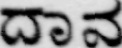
ದಾವ
